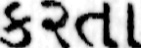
કરતા
